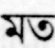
মত
